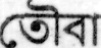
তৌবা
